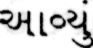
આવ્યું
